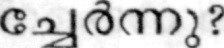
ച്ചേര്‍ന്നു?
